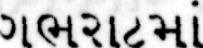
ગભરાટમાં
